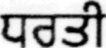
ਧਰਤੀ
